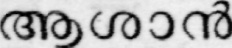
ആശാന്‍
